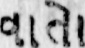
વાતો
